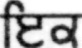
ਇਕ
